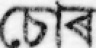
চোৰ
